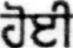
ਹੋਈ
